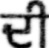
ਦੀ
